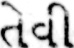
તેવી
